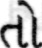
તો
